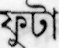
ফুটা
